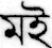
মই
